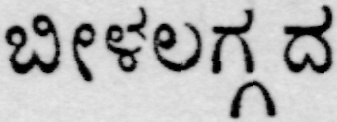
ಬೀಳಲಗ್ಗದ
